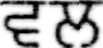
ਵਲ
